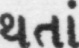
થતાં
